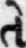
તે
